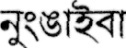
নুংঙাইবা
